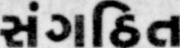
સંગઠિત
